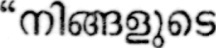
“നിങ്ങളുടെ
